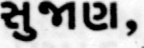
સુજાણ,
